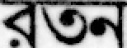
রতন
